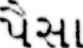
પૈસા
